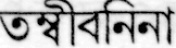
তম্বীবনিনা
